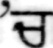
'ਚ
